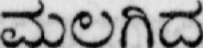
ಮಲಗಿದ
